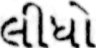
લીધો
